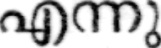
എന്നു
